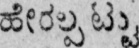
ಹೇರಲ್ಪಟ್ಟು
